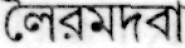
লৈরমদবা
